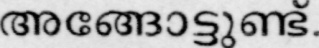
അങ്ങോട്ടുണ്ട്.
